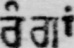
ਰੰਗਾਂ
